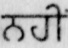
ਨਹੀਂ
